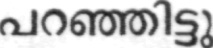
പറഞ്ഞിട്ടു
